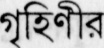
গৃহিণীর
